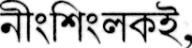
নিংশিংলকই,
